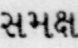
સમક્ષ
